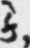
કે,
